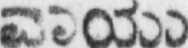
ವಾಯು
